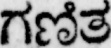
ಗಣಿತ
